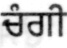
ਚੰਗੀ
